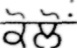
ਕੋਲੋਂ
